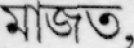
মাজত,
